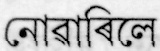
নোৱাৰিলে
